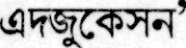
এদজুকেসন’
